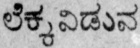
ಲೆಕ್ಕವಿಡುವ
